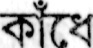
কাঁধে
